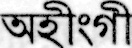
অহীংগী
